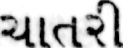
ચાતરી
